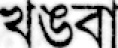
খঙবা
